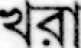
খরা
